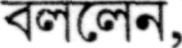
বললেন,
